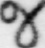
જ
